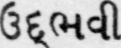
ઉદ્ભવી
